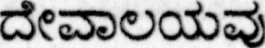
ದೇವಾಲಯವು
